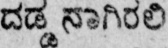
ದಡ್ಡನಾಗಿರಲಿ
